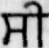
ਸੀ
